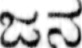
ಜನ
